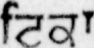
ਟਿਕਾ
